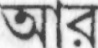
আর
